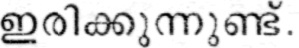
ഇരിക്കുന്നുണ്ട്.
